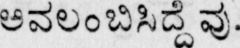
ಅವಲಂಬಿಸಿದ್ದೆವು.
